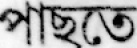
পাছতে
